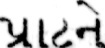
પ્રાટને
